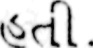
હતી.
